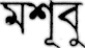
মশূবু
